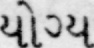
યોગ્ય
